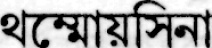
থম্মোয়সিনা
